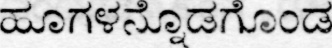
ಹೂಗಳನ್ನೊಡಗೊಂಡ
